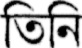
তিনি
